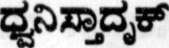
ಧ್ವನಿಸ್ತಾದೃಕ್
